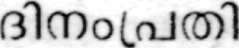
ദിനംപ്രതി
